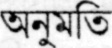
অনুমতি
